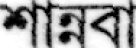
শান্নবা
